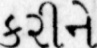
કરીને
